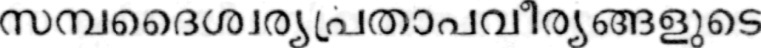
സമ്പദൈശ്വര്യപ്രതാപവീര്യങ്ങളുടെ
